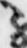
કે
